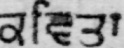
ਕਵਿਤਾ
